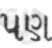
પણ
